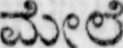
ಮೇಲೆ
